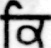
ਕਿ
